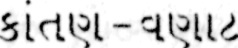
કાંતણ-વણાટ
